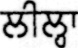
ਲੀਲ੍ਹਾ
